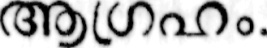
ആഗ്രഹം.
